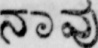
ನಾವು
